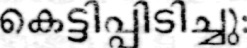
കെട്ടിപ്പിടിച്ചു:
